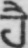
ਹੈ
